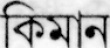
কিমান
